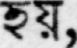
হয়,
